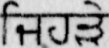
ਜਿਹੜੇ
